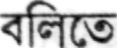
বলিতে
